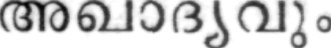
അഖാദ്യവും
